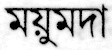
ময়ুমদা
